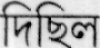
দিছিল
